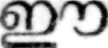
ഈ
